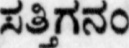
ಸತ್ತಿಗನಂ
